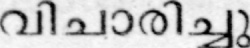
വിചാരിച്ചു
